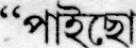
"পাইছো
